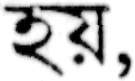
হয়,
